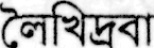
লৈখিদ্রবা
